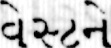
વેસ્ટને
